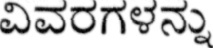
ವಿವರಗಳನ್ನು
